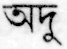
অদু
